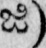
ಜಿ)
